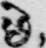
છે,
